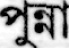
পুন্না
